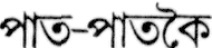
পাত-পাতকৈ
